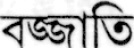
বজ্জাতি
